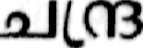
ചന്ദ്ര
